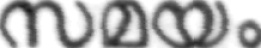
സമയം
